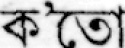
ক'তো
